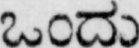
ಒಂದು
